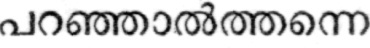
പറഞ്ഞാല്‍ത്തന്നെ
